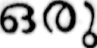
ഒരു
